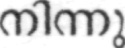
നിന്നു
